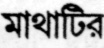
মাথাটির
